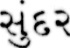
સુંદર
